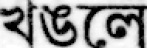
খঙলে
